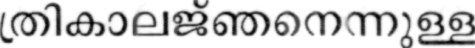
ത്രികാലജ്ഞനെന്നുള്ള
